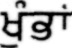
ਖੁੰਭਾਂ
